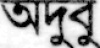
অদুবু
